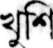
খুশি
